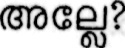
അല്ലേ?
